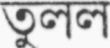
তুলল
